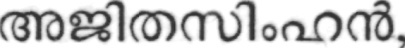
അജിതസിംഹന്‍,
